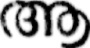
ആ
